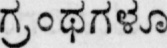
ಗ್ರಂಥಗಳೂ
